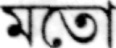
মতো
